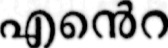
എന്റെ
